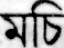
মচি
